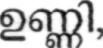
ഉണ്ണി,
